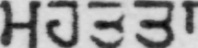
ਮਹਤਤਾ
